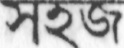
সহজ
